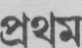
প্ৰথম
